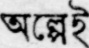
অল্পেই
